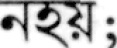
নহয়;
